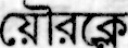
য়ৌরক্লে
